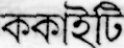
ককাইটি
